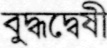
বুদ্ধদ্বেষী
